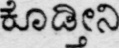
ಕೊಡ್ತೀನಿ
